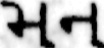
મન
